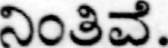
ನಿಂತಿವೆ.
